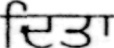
ਦਿਤਾ
